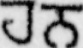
ਹਨ
